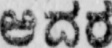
ಅದರ
